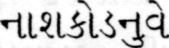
નાશકોડનુવે
